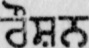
ਰੌਸ਼ਨ
